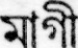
মাগী
